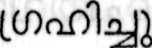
ഗ്രഹിച്ചു
